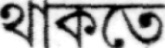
থাকতে
